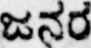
ಜನರ
